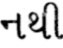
નથી
